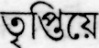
তৃপ্তিয়ে
